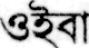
ওইবা
